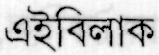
এইবিলাক
